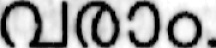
വരാം.
